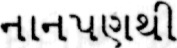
નાનપણથી
